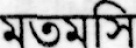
মতমসি
